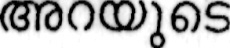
അറയുടെ
